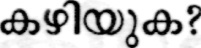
കഴിയുക?
